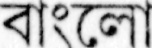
বাংলো
